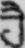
ਹੈ
